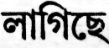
লাগিছে
